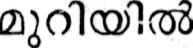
മുറിയില്‍
